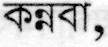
কন্নবা,
